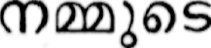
നമ്മുടെ
